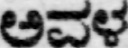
ಅವಳ
